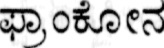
ಫ್ರಾಂಕೋನ
